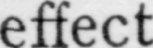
effect
